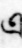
এ
